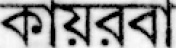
কায়রবা
